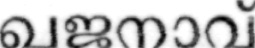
ഖജനാവ്
